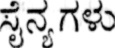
ಸೈನ್ಯಗಳು
